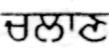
ਚਲਾਣ
